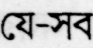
যে-সব
